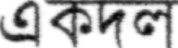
একদল
